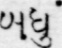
બધું
